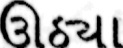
ઊઠ્યા
